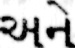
અને
